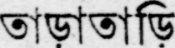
তাড়াতাড়ি
